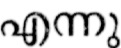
എന്നു
